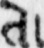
તો
